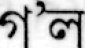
গ'ল
